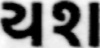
યશ
